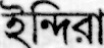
ইন্দিরা
